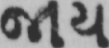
જાય
